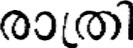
രാത്രി
